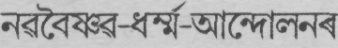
নৱৱৈষ্ণৱবৰ্ম্ম-আন্দোৱনৰ
